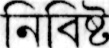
নিবিষ্ট
